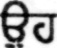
ਉਹ
